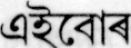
এইবোৰ
